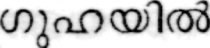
ഗുഹയില്‍
